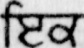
ਇਕ
